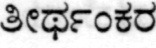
ತೀರ್ಥಂಕರ
